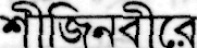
শীজিনবীরে
